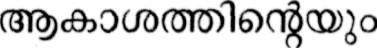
ആകാശത്തിന്റെയും
